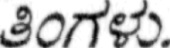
ತಿಂಗಳು.
